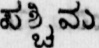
ಪಶ್ಚಿಮ
